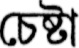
চেষ্টা
